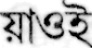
য়াওই
